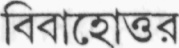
বিবাহোত্তর
